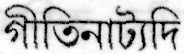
গীতিনাট্যদি
